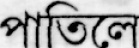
পাতিলে
